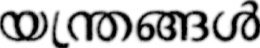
യന്ത്രങ്ങള്‍
